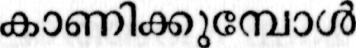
കാണിക്കുമ്പോള്‍
